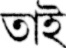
তাই
